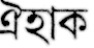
ঐহাক
